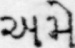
અમે
